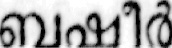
ബഷീര്‍
